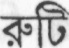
রুটি
